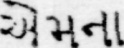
એમના
